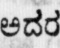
ಅದರ
